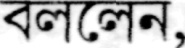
বললেন,
